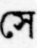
সে
